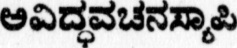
ಅವಿದ್ಧವಚನಸ್ಯಾಪಿ
